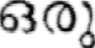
ഒരു
